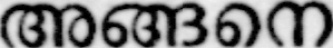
അങ്ങനെ
